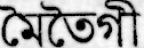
মৈতৈগী
